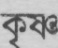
কৃষ্ণ
